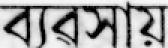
ব্যৱসায়
